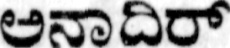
ಅನಾದಿರ್
